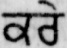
ਕਰੇ
